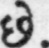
છે.
